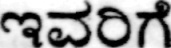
ಇವರಿಗೆ
